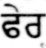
ਫੇਰ
